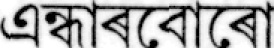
এন্ধাৰবোৰো
